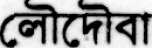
লৌদৌবা
